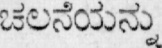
ಚಲನೆಯನ್ನು
